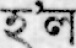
হ'ল
